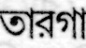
তারগা
